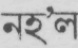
নহ'ল
